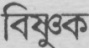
বিষ্ণুক
